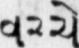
વચ્ચે
